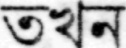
তখন
